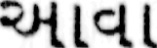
આવા
